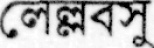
লেল্লবসু
